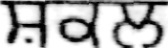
ਸ਼ਕਲ
